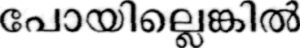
പോയില്ലെങ്കില്‍
